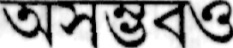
অসম্ভবও
